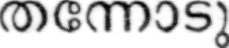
തന്നോടു
